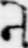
ન
